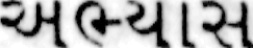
અભ્યાસ
